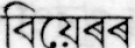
বিয়েৰৰ
